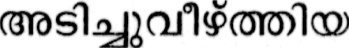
അടിച്ചുവീഴ്ത്തിയ
